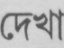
দেখা
